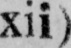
xii)
